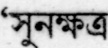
‘সুনক্ষত্র
